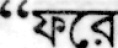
“ফরে
